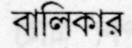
বালিকার
